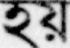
হয়
